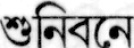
শুনিবনে
